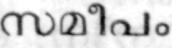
സമീപം
